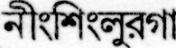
নীংশিংলুরগা
